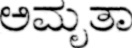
ಅಮೃತಾ
